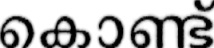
കൊണ്ട്
